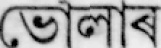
ভোলাৰ
